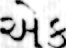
એક
